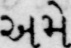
અમે
